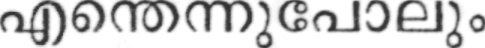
എന്തെന്നുപോലും
